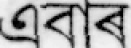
এবাৰ
